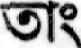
তাং
